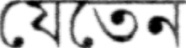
যেতেন
